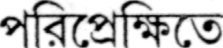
পরিপ্রেক্ষিতে
